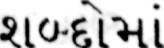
શબ્દોમાં
